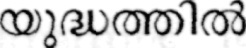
യുദ്ധത്തില്‍
